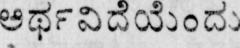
ಅರ್ಥವಿದೆಯೆಂದು
